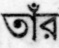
তাঁর
